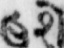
હશે
